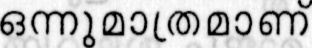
ഒന്നുമാത്രമാണ്
